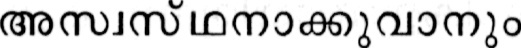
അസ്വസ്ഥനാക്കുവാനും
